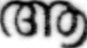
ആ
